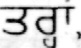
ਤਰ੍ਹਾਂ,
